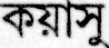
কয়াসু
